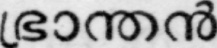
ഭ്രാന്തന്‍
